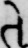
તે
